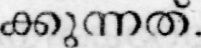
ക്കുന്നത്.
